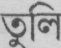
তুলি
